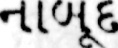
નાબૂદ
